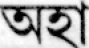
অহা
